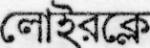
লোইরক্লে
